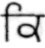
ਕਿ
